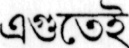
এগুতেই
